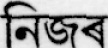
নিজৰ
